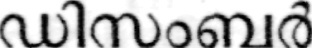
ഡിസംബര്‍
